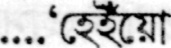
....‘হেইঁয়ো
